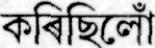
কৰিছিলোঁ
